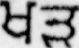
ਖੜ
